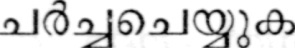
ചര്‍ച്ചചെയ്യുക
